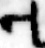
ન
